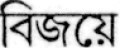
বিজয়ে
